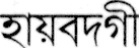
হায়বদগী
